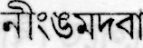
নীংঙমদবা
